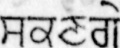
ਸਕਣਗੇ
